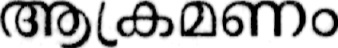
ആക്രമണം
